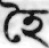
হৈ
